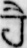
ਹੈ
